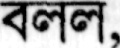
বলল,
